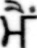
ਮੈਂ
